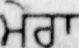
ਮੇਰਾ
